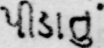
પીડાતું
